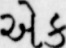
એક
